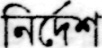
নির্দেশ
